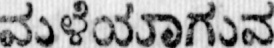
ಮಳೆಯಾಗುವ
